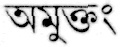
অমুক্তং
